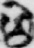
છે
